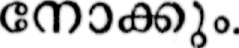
നോക്കും.
